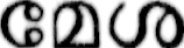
മേശ
